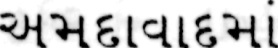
અમદાવાદમાં
